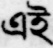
এই
